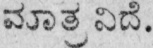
ಮಾತ್ರವಿದೆ.
